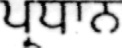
ਪ੍ਰਧਾਨ
